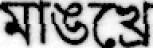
মাঙখ্রে
